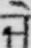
ਜੇ
